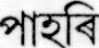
পাহৰি
